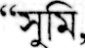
“সুমি,
